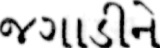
જગાડીને
